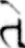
તે
